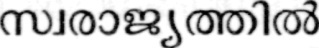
സ്വരാജ്യത്തില്‍
